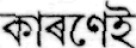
কাৰণেই
